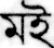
মই
